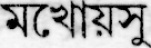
মখোয়সু
